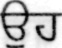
ਉਹ
